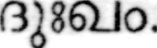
ദുഃഖം.
